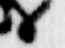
જ
